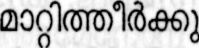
മാറ്റിത്തീര്‍ക്കു
